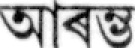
আৰম্ভ
